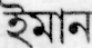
ইমান
